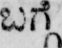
ಬಗ್ಗೆ
